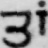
ਤਾਂ
